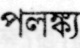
পলঙ্ক্য
